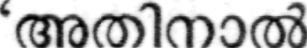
‘അതിനാല്‍
